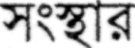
সংস্থার
